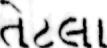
તેટલા
